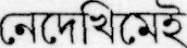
নেদেখিমেই
